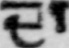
ਦਾ
